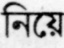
নিয়ে
